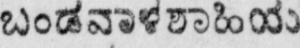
ಬಂಡವಾಳಶಾಹಿಯ
